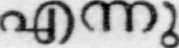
എന്നു
